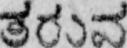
ತರುವ
